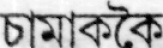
চামাককৈ
